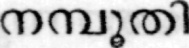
നമ്പൂതി
